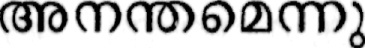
അനന്തമെന്നു
